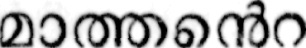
മാത്തന്റെ
